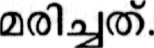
മരിച്ചത്.
